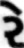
રે
